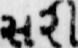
સરી
